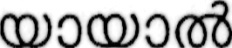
യായാല്‍
